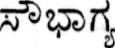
ಸೌಭಾಗ್ಯ
